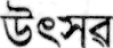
উৎসৱ
